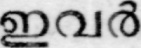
ഇവര്‍
